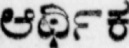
ಆರ್ಥಿಕ
